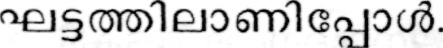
ഘട്ടത്തിലാണിപ്പോള്‍.
